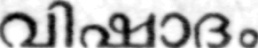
വിഷാദം
